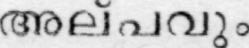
അല്പവും
